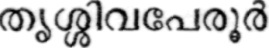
തൃശ്ശിവപേരൂര്‍
